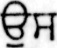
ਉਸ
